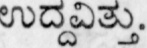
ಉದ್ದವಿತ್ತು.
